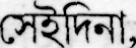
সেইদিনা,
